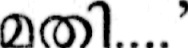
മതി....’
